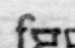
ਇਸ
